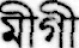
মীগী
